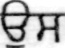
ਉਸ
